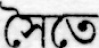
সৈতে
